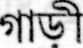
গাড়ী
